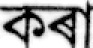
কৰা
